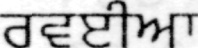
ਰਵਈਆ
